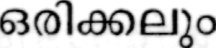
ഒരിക്കലും
